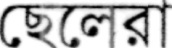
ছেলেরা
